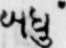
બધું
